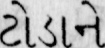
ટોડાને
